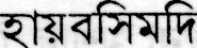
হায়বসিমদি
